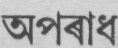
অপৰাধ
